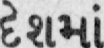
દેશમાં
